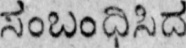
ಸಂಬಂಧಿಸಿದ
